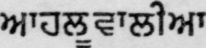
ਆਹਲੂਵਾਲੀਆ
